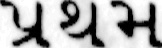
પ્રથમ
